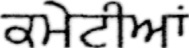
ਕਮੇਟੀਆਂ
